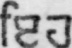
ਇਹ
